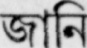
জানি
